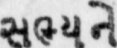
સભ્યને
